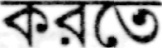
করতে
